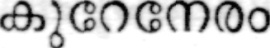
കുറേനേരം
